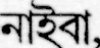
নাইবা,
